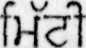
ਮਿੱਟੀ
